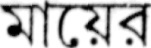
মায়ের
